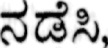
ನಡೆಸಿ,
